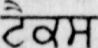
ਟੈਕਸ
